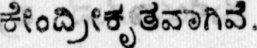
ಕೇಂದ್ರೀಕೃತವಾಗಿವೆ.
